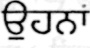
ਉਹਨਾਂ
